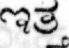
ಇತ್ತ
